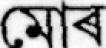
মোৰ
